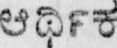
ಆರ್ಥಿಕ
